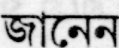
জানেন
